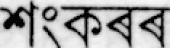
শংকৰৰ
